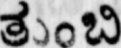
ತುಂಬಿ
